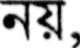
নয়,
